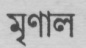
মৃণাল
